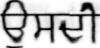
ਉਸਦੀ
